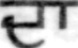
ਦਾ
